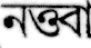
নত্তবা
